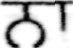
ਨਾ
